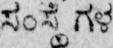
ಸಂಸ್ಥೆಗಳ
